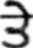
ਤੇ
